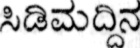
ಸಿಡಿಮದ್ದಿನ
